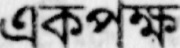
একপক্ষ
